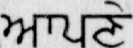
ਆਪਣੇ
